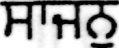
ਸਾਜਨੁ
